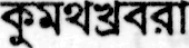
কুমথখ্রবরা
